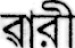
ৱারী
